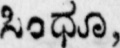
ಸಿಂಧೂ,
